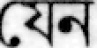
যেন
